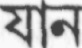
যান
